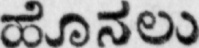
ಹೊನಲು
